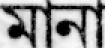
মানা
